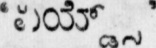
‘ಏಂii’
